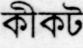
কীকট
